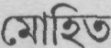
মোহিত
